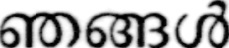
ഞങ്ങള്‍
